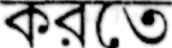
করতে
